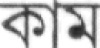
কাম
